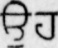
ਉਹ
